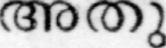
അതു
